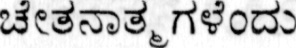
ಚೇತನಾತ್ಮಗಳೆಂದು
